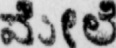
ಮೇಲೆ
